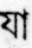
যা
